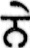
ਨੇ
